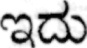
ಇದು
